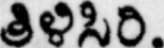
ತಿಳಿಸಿರಿ.
